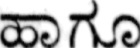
ಹಾಗೂ
